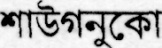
শাউগনুকো
